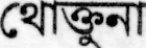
থোক্তুনা
